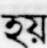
হয়
